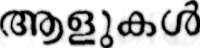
ആളുകള്‍
